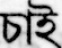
চাই
